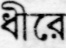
ধীরে
